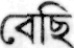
বেছি
